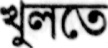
খুলতে
